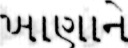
ખાણાને
